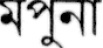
মপুনা
